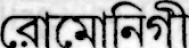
রোমোনিগী
